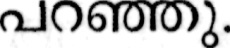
പറഞ്ഞു.
